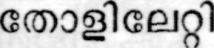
തോളിലേറ്റി
